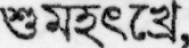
শুমহৎখ্রে,
